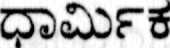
ಧಾರ್ಮಿಕ
